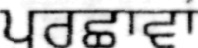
ਪਰਛਾਵਾਂ
